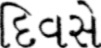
દિવસે
